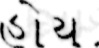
હોય.
